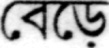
বেড়ে
